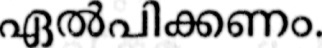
ഏല്‍പിക്കണം.
